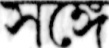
সঙ্গে
